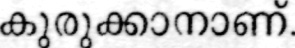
കുരുക്കാനാണ്.
